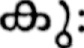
കു:
